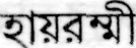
হায়রম্মী
